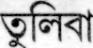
তুলিবা
